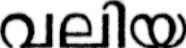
വലിയ
